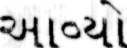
આવ્યો
